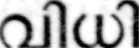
വിധി
